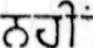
ਨਹੀਂ
